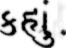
કહ્યું.
